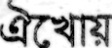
ঐখোয়
